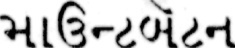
માઉન્ટબૅટન
